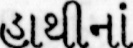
હાથીનાં
